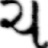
ચ
